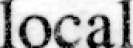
local
